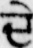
ਦੇ
